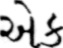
એક
